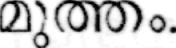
മുത്തം.
